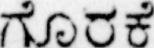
ಗೊರಕೆ
